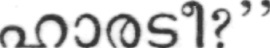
ഹാരടീ?"
